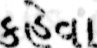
કહેવા
